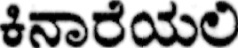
ಕಿನಾರೆಯಲಿ
